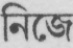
নিজে
